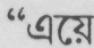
"এয়ে
